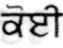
ਕੋਈ
